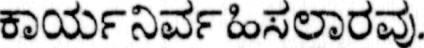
ಕಾರ್ಯನಿರ್ವಹಿಸಲಾರವು.
